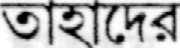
তাহাদের
